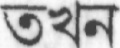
তখন
